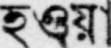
হওয়া
